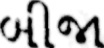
બીજા
